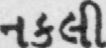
નકલી
